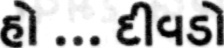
હો...દીવડો
